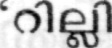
'റില്ലി
